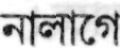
নালাগে
